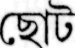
ছোট
